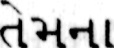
તેમના
